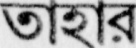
তাহার
